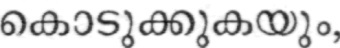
കൊടുക്കുകയും,
